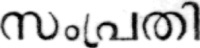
സംപ്രതി
